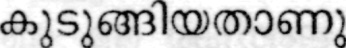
കുടുങ്ങിയതാണു
